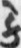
કે
